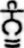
ਨੂੰ
